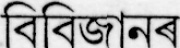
বিবিজানৰ
